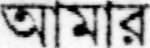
আমার
